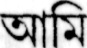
আমি
